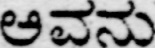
ಅವನು
